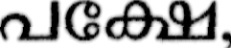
പക്ഷേ,
